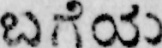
ಬಗೆಯ
